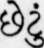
છેટું
